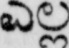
ಎಲ್ಲ
